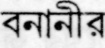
বনানীর
